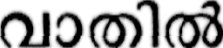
വാതില്‍
